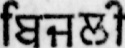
ਬਿਜਲੀ
